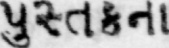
પુસ્તકના
